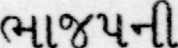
ભાજપની
